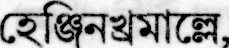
হেঞ্জিনখ্রমাল্লে,
